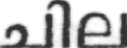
ചില
